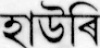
হাউৰি
